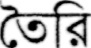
তৈরি
